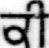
ਕੀ
